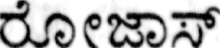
ರೋಜಾಸ್
